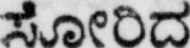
ಸೋರಿದ
